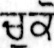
ਚੁਕੋ
